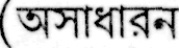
(অসাধারন
